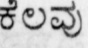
ಕೆಲವು
